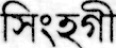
সিংহগী
